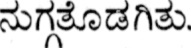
ನುಗ್ಗತೊಡಗಿತು.
